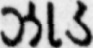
ઝાડ
